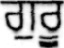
ਗੁਰੂ
